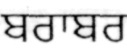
ਬਰਾਬਰ
